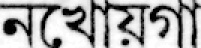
নখোয়গা
